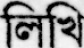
লিখি
